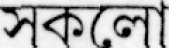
সকলো
